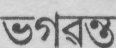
ভগৱন্ত
